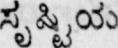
ಸೃಷ್ಟಿಯ
